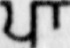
ਪਾ
